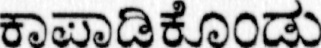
ಕಾಪಾಡಿಕೊಂಡು
